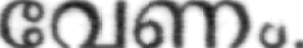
വേണം.
